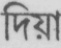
দিয়া
